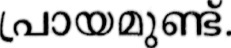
പ്രായമുണ്ട്.
